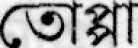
তোপ্পা
